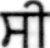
ਸੀ
